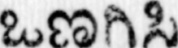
ಒಣಗಿಸಿ
